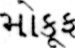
મોકૂફ
